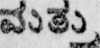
ಮತ್ತು
